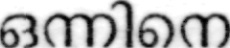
ഒന്നിനെ
